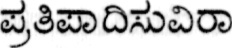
ಪ್ರತಿಪಾದಿಸುವಿರಾ
